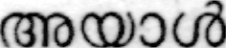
അയാള്‍
